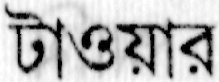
টাওয়ার
